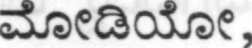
ಮೋಡಿಯೋ,
